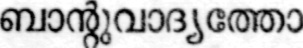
ബാന്റുവാദ്യത്തോ
